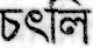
চৎলি
